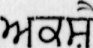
ਅਕਸ਼ੈ
